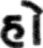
હો
